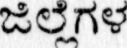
ಜಿಲ್ಲೆಗಳ
